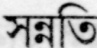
সন্নতি
